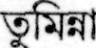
তুমিন্না
